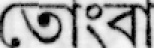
তোংবা
